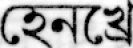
হেনখ্রে
